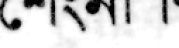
শেংনা
